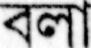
বলা
